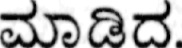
ಮಾಡಿದ.
